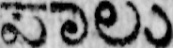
ಪಾಲು
